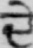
ਦੇ
